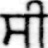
ਸੀ
